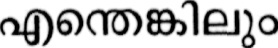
എന്തെങ്കിലും
